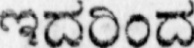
ಇದರಿಂದ
